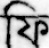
ফি
